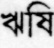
ঋষি
